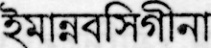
ইমান্নবসিগীনা
